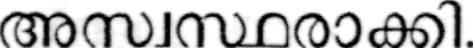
അസ്വസ്ഥരാക്കി.
